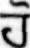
ਹੋ
